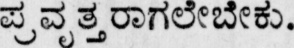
ಪ್ರವೃತ್ತರಾಗಲೇಬೇಕು.
